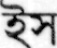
ইস
